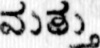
ಮತ್ತು
